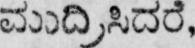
ಮುದ್ರಿಸಿದರೆ,
